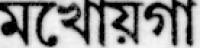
মখোয়গা
